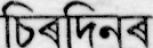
চিৰদিনৰ
